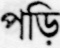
পড়ি
